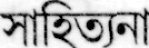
সাহিত্যনা
